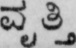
ವೃತ್ತಿ
